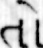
તો
